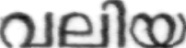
വലിയ
